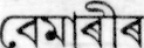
বেমাৰীৰ
